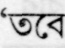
‘তবে
